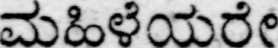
ಮಹಿಳೆಯರೇ
